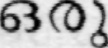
ഒരു
